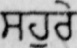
ਸਹੁਰੇ
